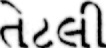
તેટલી
